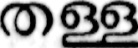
തള്ള
